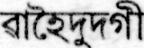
ৱাহৈদুদগী
